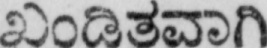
ಖಂಡಿತವಾಗಿ
